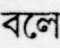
বলে
